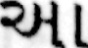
આ
